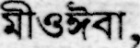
মীওঈবা,
